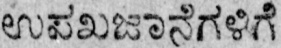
ಉಪಖಜಾನೆಗಳಿಗೆ
